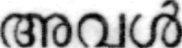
അവള്‍
